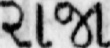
રાજા
